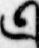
এ
